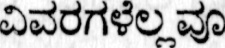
ವಿವರಗಳೆಲ್ಲವೂ
